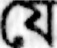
যে
